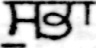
ਸੁਭਾ
